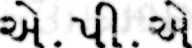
એ.પી.એ.
